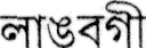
লাঙবগী
